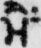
ਮੈਂ
